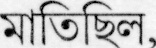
মাতিছিল,
